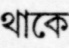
থাকে
